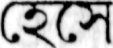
হেসে
